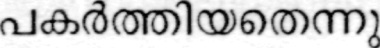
പകര്‍ത്തിയതെന്നു
